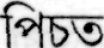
পিচত
